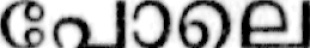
പോലെ
